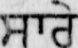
ਸਾਰੇ
